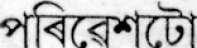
পৰিৱেশটো
